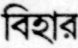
বিহার
